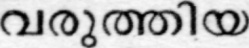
വരുത്തിയ
